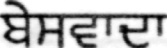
ਬੇਸਵਾਦਾ
